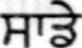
ਸਾਡੇ
